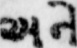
અને
